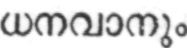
ധനവാനും
